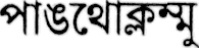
পাঙথোক্লম্মু
